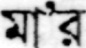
মা’র
